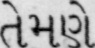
તેમણે
